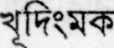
খূদিংমক
